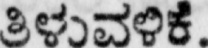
ತಿಳುವಳಿಕೆ.
